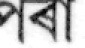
পৰা
